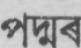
পদ্মৰ
